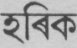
হৰিক
